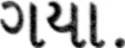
ગયા.
